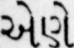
એણે
